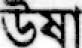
উষা
